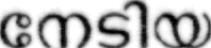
നേടിയ
